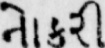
નોકરી
